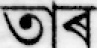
তাৰ
